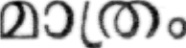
മാത്രം
